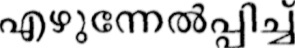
എഴുന്നേല്‍പ്പിച്ച്
